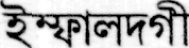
ইম্ফালদগী
